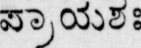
ಪ್ರಾಯಶಃ
